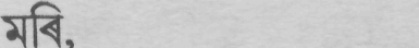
মৰি,
